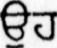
ਉਹ
